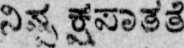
ನಿಷ್ಪಕ್ಷಪಾತತೆ
